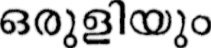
ഒരുളിയും
